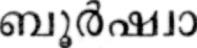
ബൂര്‍ഷ്വാ
